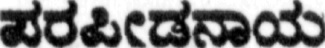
ಪರಪೀಡನಾಯ
